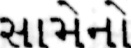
સામેનો
